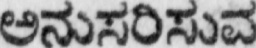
ಅನುಸರಿಸುವ
